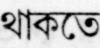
থাকতে
